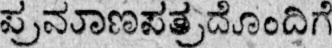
ಪ್ರಮಾಣಪತ್ರದೊಂದಿಗೆ
